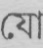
যো
